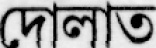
দোলাত
